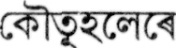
কৌতূহলেৰে
